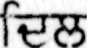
ਦਿਲ
